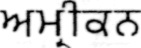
ਅਮ੍ਰੀਕਨ
